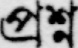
প্রশ্ন
